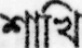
শাখি
